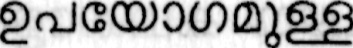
ഉപയോഗമുള്ള
